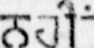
ਨਹੀਂ
